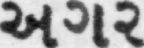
અગર
